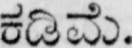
ಕಡಿಮೆ.
